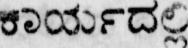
ಕಾರ್ಯದಲ್ಲಿ
